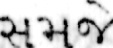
સમજે
